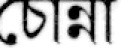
চোন্না
